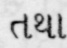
તથા
